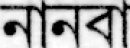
নানবা
